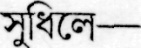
সুধিলে-
